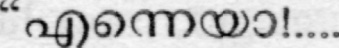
"എന്നെയാ!....
